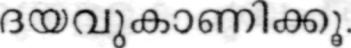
ദയവുകാണിക്കൂ.
